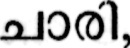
ചാരി,
